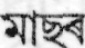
মাছৰ
